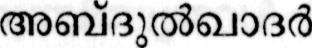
അബ്ദുല്‍ഖാദര്‍
